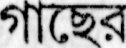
গাছের
